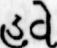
હવે
